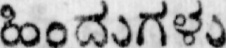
ಹಿಂದುಗಳು
